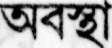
অবস্থা
